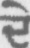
ਦੇ
